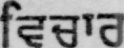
ਵਿਚਾਰ
